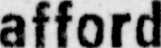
afford
